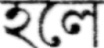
হলে
